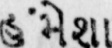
હંમેશા
